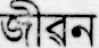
জীৱন
